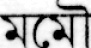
মমৌ
